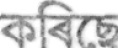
কৰিছে
